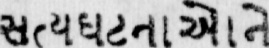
સત્યઘટનાઓને
